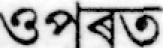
ওপৰত
